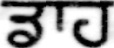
ਡਾਹ
